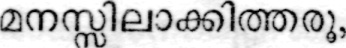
മനസ്സിലാക്കിത്തരൂ,
